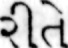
રીતે
